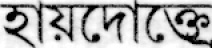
হায়দোক্ত্রে
